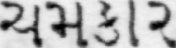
ચમકાર
